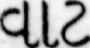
વાટ
